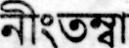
নীংতম্বা
